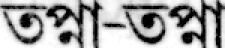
তপ্না-তপ্না
